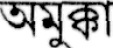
অমুক্কা
